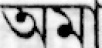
অমা
